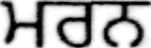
ਮਰਨ
